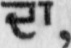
ਦਾ,
